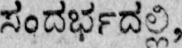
ಸಂದರ್ಭದಲ್ಲಿ,
